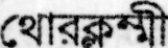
থোরগক্লম্মী
